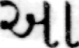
આ
